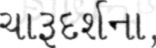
ચારૂદર્શના,
